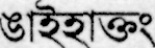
ঙাইহাক্তং
